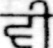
ਵੀ
